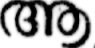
ആ
